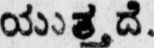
ಯುತ್ತದೆ.
